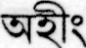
অহীং
